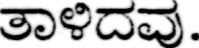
ತಾಳಿದವು.
